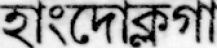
হাংদোক্লগা
